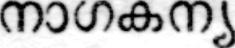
നാഗകന്യ
